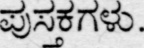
ಪುಸ್ತಕಗಳು.
